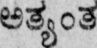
ಅತ್ಯಂತ
